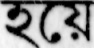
হয়ে
